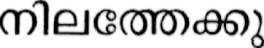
നിലത്തേക്കു
